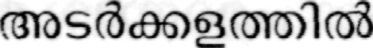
അടര്‍ക്കളത്തില്‍
